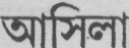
আসিলা
